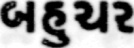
બહુચર
